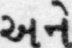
અને
